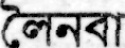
লৈনবা
